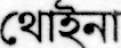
থোইনা
